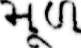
મૂળ
